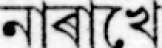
নাৰাখে
